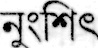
নুংশিৎ
